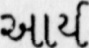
આર્ય
